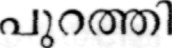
പുറത്തി
